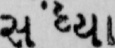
સંધ્યા
